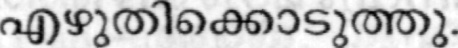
എഴുതിക്കൊടുത്തു.
